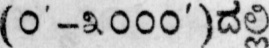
(೦-೩೦೦೦)ದಲ್ಲಿ
